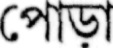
পোড়া
